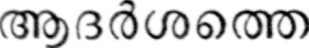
ആദര്‍ശത്തെ
